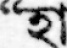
“হা
